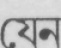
যেন
